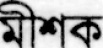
মীশক
